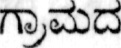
ಗ್ರಾಮದ
